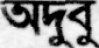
অদুবু
